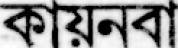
কায়নবা
